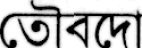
তৌবদো
